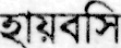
হায়বসি
